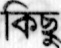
কিছু
